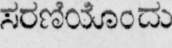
ಸರಣಿಯೊಂದು
